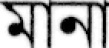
মানা
